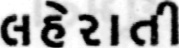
લહેરાતી
